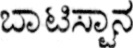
ಬಾಟಿಸ್ಟಾನ
